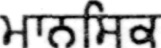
ਮਾਨਸਿਕ
